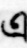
এ
